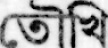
তৌখি
